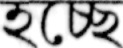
হচ্ছে
